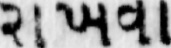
રાખવા
